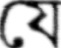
যে
